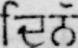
ਦਿਨੋ
